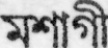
মশাগী
